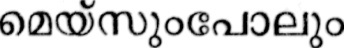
മെയ്സുംപോലും
